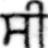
ਸੀ
